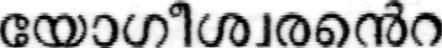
യോഗീശ്വരന്റെ
